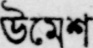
উমেশ
